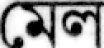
মেল
